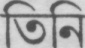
তিনি
